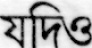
যদিও
